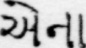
એના
